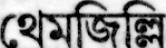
থেমজিল্লি
